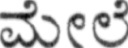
ಮೇಲೆ
